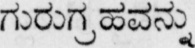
ಗುರುಗ್ರಹವನ್ನು
